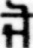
ਜੋ
